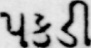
પકડી
